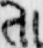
તો
